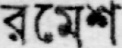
রমেশ
